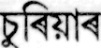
চুৰিয়াৰ
